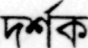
দর্শক
